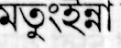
মতুংইন্না
